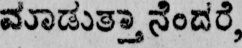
ಮಾಡುತ್ತಾನೆಂದರೆ,
